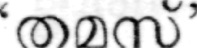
‘തമസ്'
